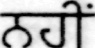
ਨਹੀਂ
